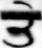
ਤੇ
